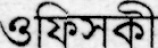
ওফিসকী
